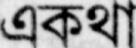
একথা
